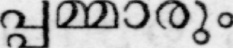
പ്പമ്മാരും
